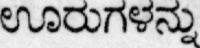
ಊರುಗಳನ್ನು
